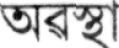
অৱস্থা
